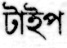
টাইপ
